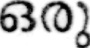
ഒരു
